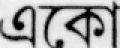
একো
